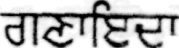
ਗਣਾਇਣਾ
